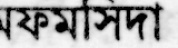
মফমসিদা
